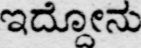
ಇದ್ದೋನು
